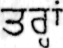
ਤਰ੍ਹਾਂ
